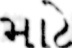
માટે
